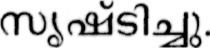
സൃഷ്ടിച്ചു.
